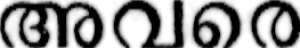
അവരെ
